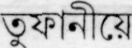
তুফানীয়ে
